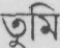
তুমি
